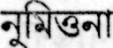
নুমিত্তনা
